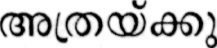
അത്രയ്ക്കു
